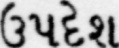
ઉપદેશ
